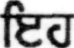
ਇਹ
